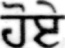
ਹੋਏ
